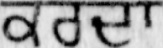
ਕਰਦਾ
